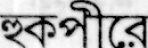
হুকপীরে
